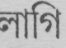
লাগি
